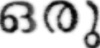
ഒരു
